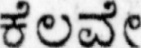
ಕೆಲವೇ
